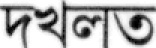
দখলত
